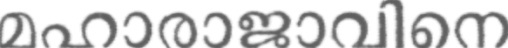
മഹാരാജാവിനെ
